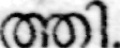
ത്തി.
